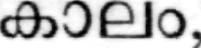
കാലം,
